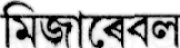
মিজাৰেবল
